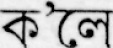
ক'লে
